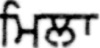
ਮਿਲਾ
